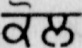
ਕੋਲ
